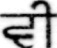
ਵੀ
